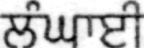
ਲੰਘਾਈ
